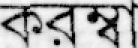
করম্বা
